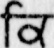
ਕਿ
